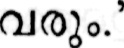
വരും.'
